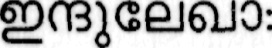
ഇന്ദുലേഖാ:
